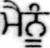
ਮੈਨੂੰ
